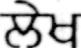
ਲੇਖ
